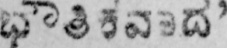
ಭೌತಿಕವಾದ’
